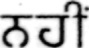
ਨਹੀਂ
